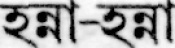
হন্না-হন্না
